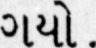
ગયો.
